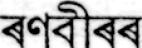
ৰণবীৰৰ
